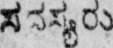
ಸದಸ್ಯರು
